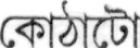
কোঠাটো
